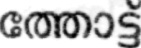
ത്തോട്ട്
